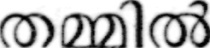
തമ്മില്‍
